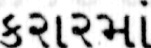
કરારમાં
